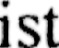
ist
